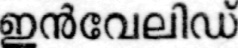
ഇന്‍വേലിഡ്
